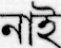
নাই
